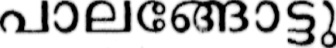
പാലങ്ങോട്ടു
